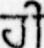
ਹੀ
